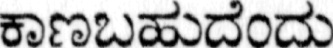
ಕಾಣಬಹುದೆಂದು
